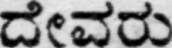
ದೇವರು
